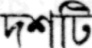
দশটি
